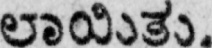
ಲಾಯಿತು.
